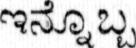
ಇನ್ನೊಬ್ಬ
